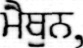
ਮੈਥੁਨ,
